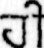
ਹੀ
